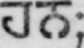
ਹਨ;
